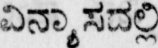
ವಿನ್ಯಾಸದಲ್ಲಿ
